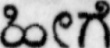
ಹೀಗೆ
